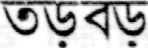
তড়বড়
